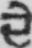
ਦੇ
